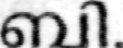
ബി.
